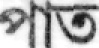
পাত
